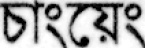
চাংয়েং
